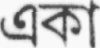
একা
